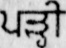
ਪੜ੍ਹੀ
